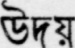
উদয়
